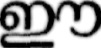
ഈ
